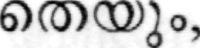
തെയും,
